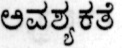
ಅವಶ್ಯಕತೆ
